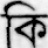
কি
